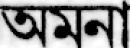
অমনা
